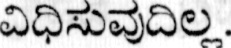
ವಿಧಿಸುವುದಿಲ್ಲ.
